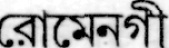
রোমেনগী
